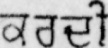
ਕਰਦੀ
